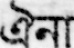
ঐনা
